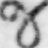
જ
